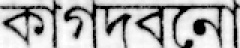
কাগদবনো
